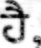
ਹੈ,
